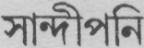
সান্দীপনি
